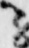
કે
